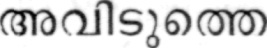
അവിടുത്തെ
